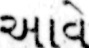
આવે
